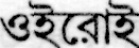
ওইরোই
